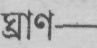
ঘ্ৰাণ-
